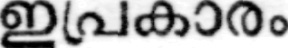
ഇപ്രകാരം
